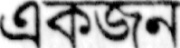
একজন
